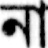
না
